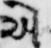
એ
